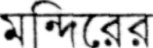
মন্দিরের
